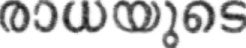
രാധയുടെ
